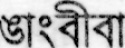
ঙাংবীবা
